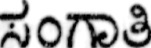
ಸಂಗಾತಿ
